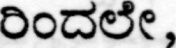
ರಿಂದಲೇ,
